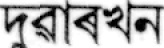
দুৱাৰখন
